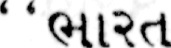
"ભારત
